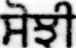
ਸੋਝੀ
